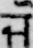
ਜੋ
